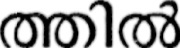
ത്തില്‍
